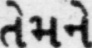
તેમને
